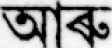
আৰু
